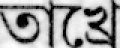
তাখ্রে
